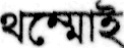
থম্মোই
